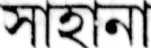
সাহানা
